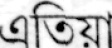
এতিয়া
